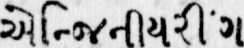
એન્જિનીયરીંગ
